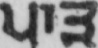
ਪਾੜ
